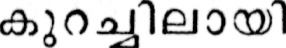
കുറച്ചിലായി
